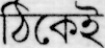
ঠিকেই
